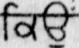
ਕਿਉਂ
